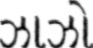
ઝાઝો
